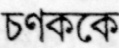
চণককে
